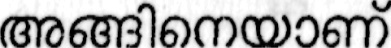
അങ്ങിനെയാണ്
